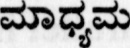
ಮಾಧ್ಯಮ
